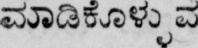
ಮಾಡಿಕೊಳ್ಳುವ
